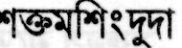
শক্তমশিংদুদা
